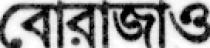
বোরাজাও
